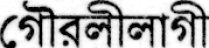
গৌরলীলাগী
